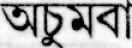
অচুমবা
